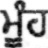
ਮੂੰਹ
